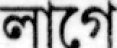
লাগে
